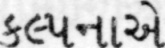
કલ્પનાએ
